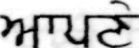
ਆਪਣੇ
